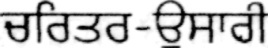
ਚਰਿਤਰ-ਉਸਾਰੀ
